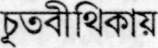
চূতবীথিকায়
